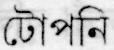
টোপনি
